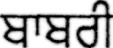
ਬਾਬਰੀ
